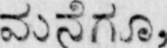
ಮನೆಗೂ,
